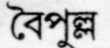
বৈপুল্ল
